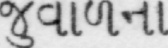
જુવાળના
